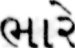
ભારે
